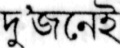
দু'জনেই
